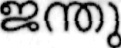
ജന്തു
